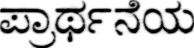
ಪ್ರಾರ್ಥನೆಯ
